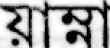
য়াম্না
